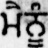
ਮੈਨੂੰ
